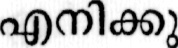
എനിക്കു
